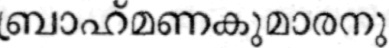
ബ്രാഹ്മണകുമാരനു
